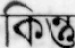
কিন্তু
